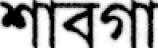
শাবগা
